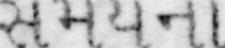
સમયના
